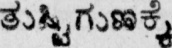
ತುಷ್ಟಿಗುಣಕ್ಕೆ
